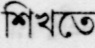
শিখতে
